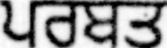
ਪਰਬਤ
